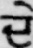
ਦੇ
